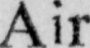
Air
